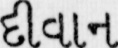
દીવાન
